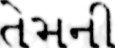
તેમની
